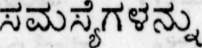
ಸಮಸ್ಯೆಗಳನ್ನು
